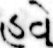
હવે
